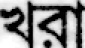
খরা
